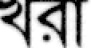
খরা
